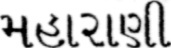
મહારાણી
